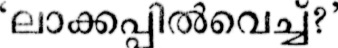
‘ലാക്കപ്പില്‍വെച്ച്?’
